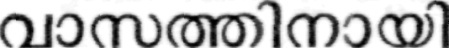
വാസത്തിനായി
